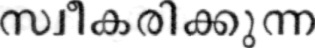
സ്വീകരിക്കുന്ന
